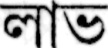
লাভ
